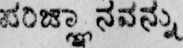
ಪರಿಜ್ಞಾನವನ್ನು
